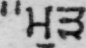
''ਮੁੜ
